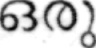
ഒരു
